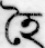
হৈ
